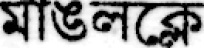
মাঙলক্লে
